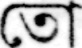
তো
